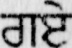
ਗਏ
